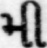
મી
